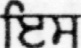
ਇਸ
